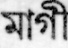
মাগী
